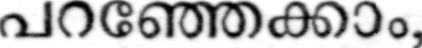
പറഞ്ഞേക്കാം,
